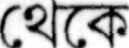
থেকে
